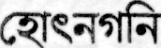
হোৎনগনি
